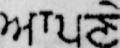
ਆਪਣੇ
